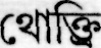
থোক্ত্রি
